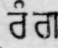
ਰੰਗ
